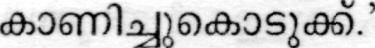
കാണിച്ചുകൊടുക്ക്.’
